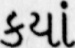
કયાં
